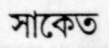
সাকেত
